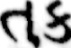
તક
